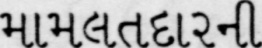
મામલતદારની
